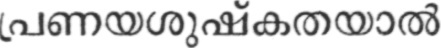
പ്രണയശുഷ്കതയാല്‍
